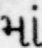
માં
